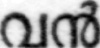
വന്‍
